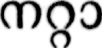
നറ്റാ
